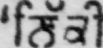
'ਨਿੱਕੀ
